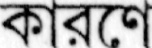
কারণে
